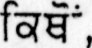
ਕਿਥੋਂ,
